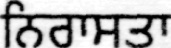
ਨਿਰਾਸਤਾ
